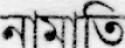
নামাতি
